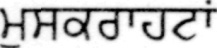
ਮੁਸਕਰਾਹਟਾਂ
